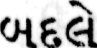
બદલે
